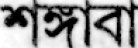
শঙ্গাবা
